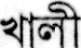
খালী
